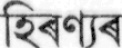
হিৰণ্যৰ
